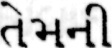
તેમની
